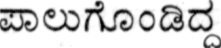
ಪಾಲುಗೊಂಡಿದ್ದ
